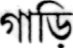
গাড়ি
